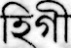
হিগী
